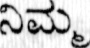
ನಿಮ್ಮ
